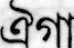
ঐগা
